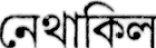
নেথাকিল
